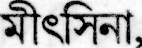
মীৎসিনা,
